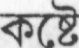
কষ্টে
